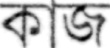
কাজ
